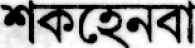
শকহেনবা
